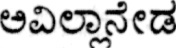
ಅವಿಲ್ಲಾನೇಡ
